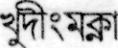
খুদীংমক্না
